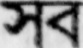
সব
